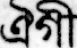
ঐগী
